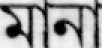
মানা
